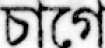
চাগে
